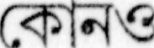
কোনও
